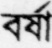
বর্ষা
